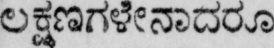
ಲಕ್ಷಣಗಳೇನಾದರೂ
